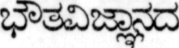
ಭೌತವಿಜ್ಞಾನದ
